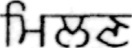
ਮਿਲਣ
